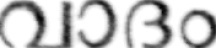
വാദം
